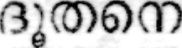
ദൂതനെ
